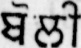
ਬੋਲੀ
